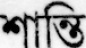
শান্তি
